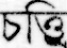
চত্ত্রি
